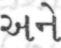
અને
